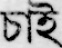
চাই
